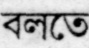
বলতে
